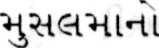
મુસલમાનો
